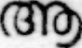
ആ
